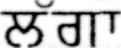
ਲੱਗਾ
